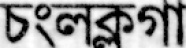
চংলক্লগা
